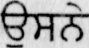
ਉਸਨੇ
